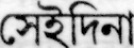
সেইদিনা
